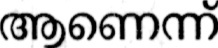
ആണെന്ന്
